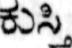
ಕುಸ್ತಿ
